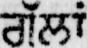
ਗੱਲਾਂ
